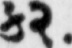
કર.
